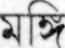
মঙ্গি
